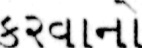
કરવાનો
